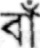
বাঁ
